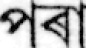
পৰা
